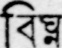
বিঘ্ন
